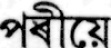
পৰীয়ে
